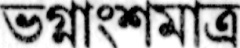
ভগ্নাংশমাত্র
